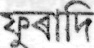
ফুৰাদি
